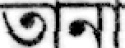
তানা
